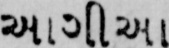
આગીઆ
